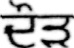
ਦੌੜ
